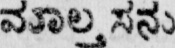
ಮಾಲ್ತಸನು
